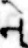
ને
